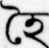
হৈ
